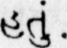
હતું.
